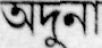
অদুনা
